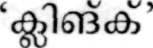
'ക്ലിങ്ക്'
